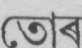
তোৰ
